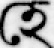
হে
